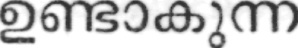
ഉണ്ടാകുന്ന
